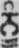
ਨੂੰ
